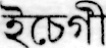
ইচেগী
